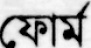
ফোর্ম
